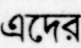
এদের
